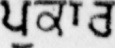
ਪੁਕਾਰ
